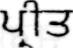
ਪ੍ਰੀਤ
